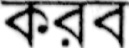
করব
